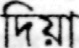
দিয়া
